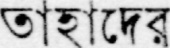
তাহাদের
